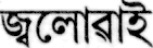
জ্বলোৱাই
